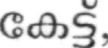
കേട്ട്,
